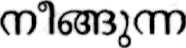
നീങ്ങുന്ന
